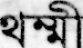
থম্মী
